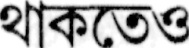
থাকতেও
